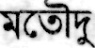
মতৌদু
